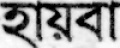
হায়বা
